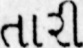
તારી
